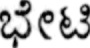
ಭೇಟಿ
